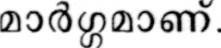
മാര്‍ഗ്ഗമാണ്.
